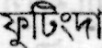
ফুটিংদা
